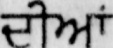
ਦੀਆਂ
